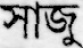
সাজু
